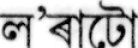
ল'ৰাটো
